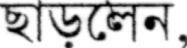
ছাড়লেন,
